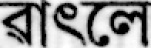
ৱাৎলে
